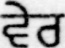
ਵੇਰ
